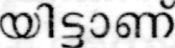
യിട്ടാണ്
